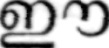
ഈ
